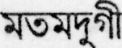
মতমদুগী
